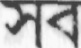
সব
